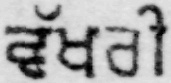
ਵੱਖਰੀ
